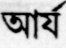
আর্য
